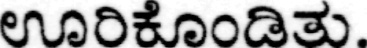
ಊರಿಕೊಂಡಿತು.
